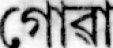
গোৱা
